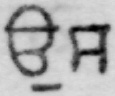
ਉਸ
